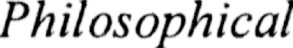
Philosophical
